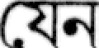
যেন
